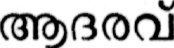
ആദരവ്
